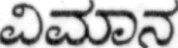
ವಿಮಾನ
